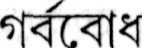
গর্ববোধ
